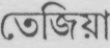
তেজিয়া
